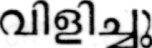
വിളിച്ചു
